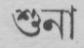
শুনা
